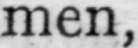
men,
